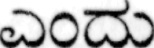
ಎಂದು
